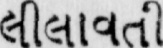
લીલાવતી
